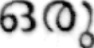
ഒരു
